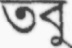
তবু
